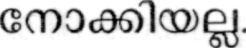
നോക്കിയല്ല.
